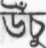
উঁচু
